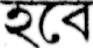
হবে
